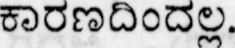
ಕಾರಣದಿಂದಲ್ಲ.
